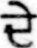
ਦੇ
